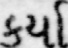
કર્યા
